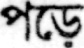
পড়ে
